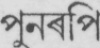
পুনৰপি
